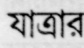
যাত্রার
